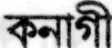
কনাগী
